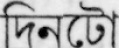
দিনটো
